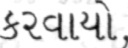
કરવાયો,
